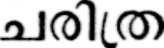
ചരിത്ര
